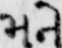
મને
